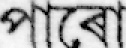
পাৰো
